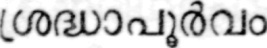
ശ്രദ്ധാപൂര്‍വം
